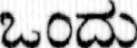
ಒಂದು
